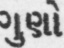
ગુણો
